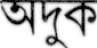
অদুক
